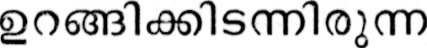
ഉറങ്ങിക്കിടന്നിരുന്ന
